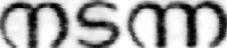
നടന്ന
